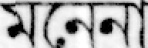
মনেনা
